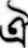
ঐ
